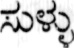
ಸುಳ್ಳು
